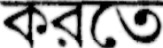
করতে
